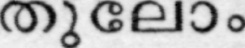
തുലോം
